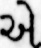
એ
